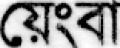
য়েংবা
